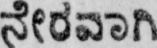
ನೇರವಾಗಿ
